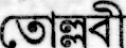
তোল্লবী
